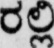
ರಲ್ಲಿ
